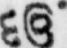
દઉંં
